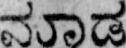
ಮಾಡ
